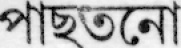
পাছতনো
